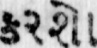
કરશો
